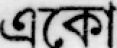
একো
